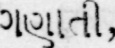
ગણાતી,
